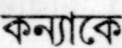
কন্যাকে
